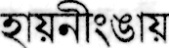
হায়নীংঙায়
